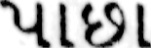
પાછા
